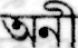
অনী
